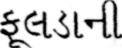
ફૂલડાની
